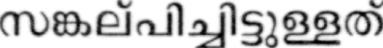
സങ്കല്പിച്ചിട്ടുള്ളത്
